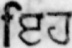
ਇਹ
